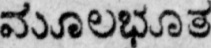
ಮೂಲಭೂತ
